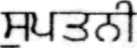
ਸੁਪਤਨੀ
